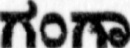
ಗಂಗಾ
